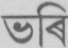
ভৰি
